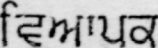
ਵਿਆਪਕ
